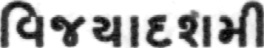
વિજયાદશમી
